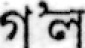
গ'ল
